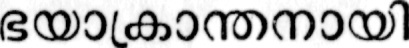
ഭയാക്രാന്തനായി
